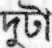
দুটা
